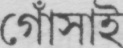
গোঁসাই
